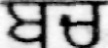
ਬਚ
